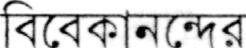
বিবেকানন্দের
